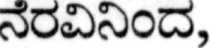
ನೆರವಿನಿಂದ,
